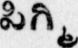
ಪಿಗ್ಮಿ
